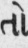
તો
